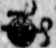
ಈ
